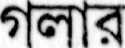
গলার
